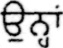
ਉਨ੍ਹਾਂ
